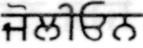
ਜੋਲੀਓਨ
